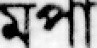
মপা
